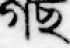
গছ
